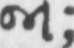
જા;
